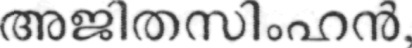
അജിതസിംഹന്‍,
